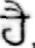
ਹੈ,
